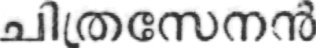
ചിത്രസേനന്‍
